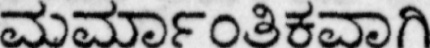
ಮರ್ಮಾಂತಿಕವಾಗಿ
